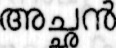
അച്ഛന്‍
